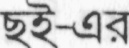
ছই-এর
